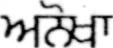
ਅਨੋਖਾ
